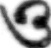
ও
